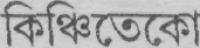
কিঞ্চিতেকো
